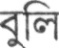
বুলি
